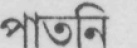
পাতনি
